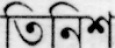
তিনিশ
